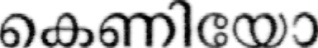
കെണിയോ
